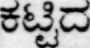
ಕಟ್ಟಿದ
